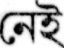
নেই
